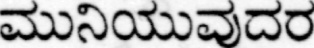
ಮುನಿಯುವುದರ
